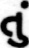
તું
